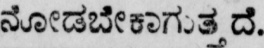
ನೋಡಬೇಕಾಗುತ್ತದೆ.
